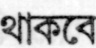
থাকবে
